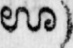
ಊ)
